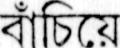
বাঁচিয়ে
